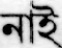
নাই
